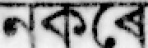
নকৰে
